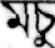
মচু
